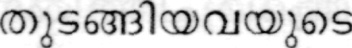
തുടങ്ങിയവയുടെ
